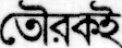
তৌরকই
